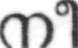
നീ
